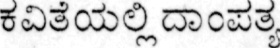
ಕವಿತೆಯಲ್ಲಿದಾಂಪತ್ಯ
